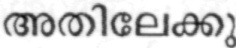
അതിലേക്കു
